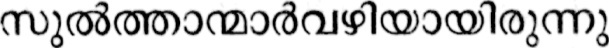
സുല്‍ത്താന്മാര്‍വഴിയായിരുന്നു
